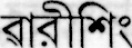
ৱারীশিং
